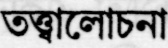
তত্ত্বালোচনা
